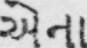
એના
